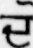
ਦੋ
